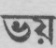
ভয়
